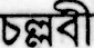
চল্লবী
